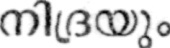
നിദ്രയും
